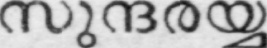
സുന്ദരയ്യ
